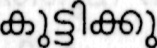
കുട്ടിക്കു
